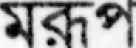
মরূপ
